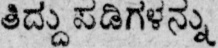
ತಿದ್ದುಪಡಿಗಳನ್ನು
